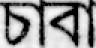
চাবা
